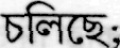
চলিছে;
